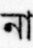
না
